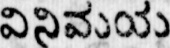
ವಿನಿಮಯ
